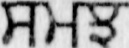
ਸਮਝ
